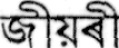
জীয়ৰী
